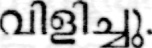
വിളിച്ചു.
